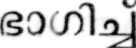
ഭാഗിച്ച്
